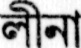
লীনা
